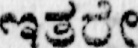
ಇತರೇ
